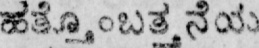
ಹತ್ತೊಂಬತ್ತನೆಯ
